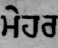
ਮੇਹਰ
